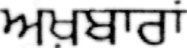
ਅਖ਼ਬਾਰਾਂ
